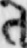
તે
